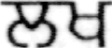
ਲਖ
